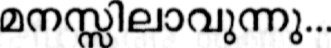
മനസ്സിലാവുന്നു...
